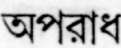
অপরাধ
